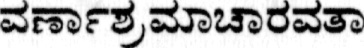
ವರ್ಣಾಶ್ರಮಾಚಾರವತಾ
